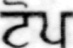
ਟੋਪ
